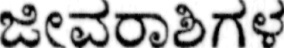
ಜೀವರಾಶಿಗಳ
